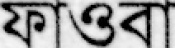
ফাওবা
